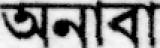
অনাবা
